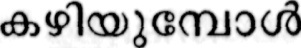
കഴിയുമ്പോള്‍
